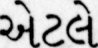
એટલે
